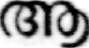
ആ
